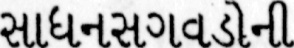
સાધનસગવડોની
